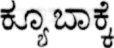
ಕ್ಯೂಬಾಕ್ಕೆ
